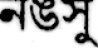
নঙসু
